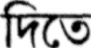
দিতে
